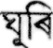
ঘূৰি
